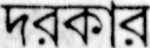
দরকার
